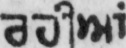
ਰਹੀਆਂ
